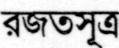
রজতসূত্র
